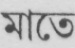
মাতে
